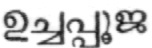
ഉച്ചപ്പൂജ
